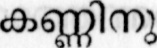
കണ്ണിനു
